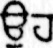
ਉਹ
